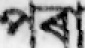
পৰা
